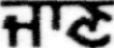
ਜਾਣ
